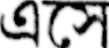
এসে
